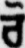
ਰੋ
